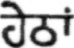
ਹੇਠਾਂ
